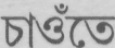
চাওঁতে
